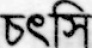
চৎসি
